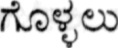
ಗೊಳ್ಳಲು
